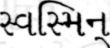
સ્વસ્મિન્
